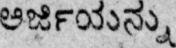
ಅರ್ಜಿಯನ್ನು
